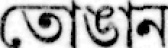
তোঙান
